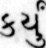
કર્યું
